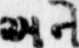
અને
